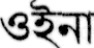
ওইনা
